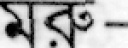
মরু-
